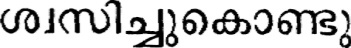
ശ്വസിച്ചുകൊണ്ടു
